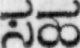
ಸಹ
